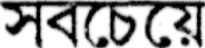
সবচেয়ে
